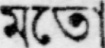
মতো
